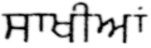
ਸਾਖੀਆਂ
